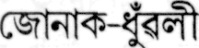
জোনাক-ধুঁৱলী
